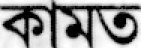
কামত
